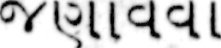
જણાવવા
